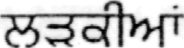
ਲੜਕੀਆਂ
